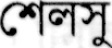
শেলসু
